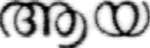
ആയ
